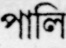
পালি
